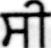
ਸੀ
